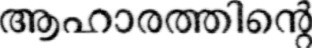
ആഹാരത്തിന്റെ
